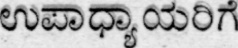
ಉಪಾಧ್ಯಾಯರಿಗೆ
